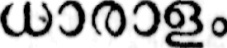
ധാരാളം
